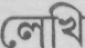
লেখি
